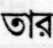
তার
